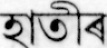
হাতীৰ
